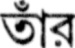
তাঁর
